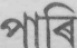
পাৰি
